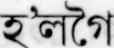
হ'লগৈ
